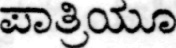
ಪಾತ್ರಿಯೂ
